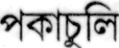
পকাচুলি
